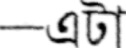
–এটা
